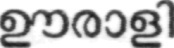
ഊരാളി
